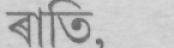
ৰাতি,
